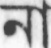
না
